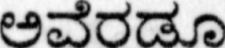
ಅವೆರಡೂ
